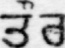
ਤੌਰ
